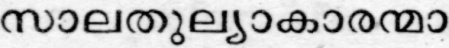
സാലതുല്യാകാരന്മാ
